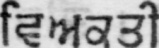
ਵਿਅਕਤੀ
